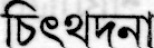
চিৎথদনা
